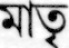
মাতৃ
